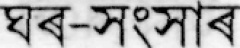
ঘৰ-সংসাৰ
